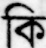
কি
